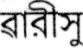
ৱারীসু
